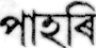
পাহৰি
